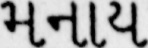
મનાય
